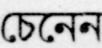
চেনেন
